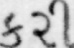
કરી
